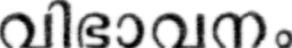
വിഭാവനം
